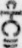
ਨੂੰ
